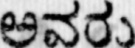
ಅವರು
